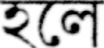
হলে
